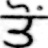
ਤੋਂ
